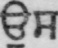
ਉਸ
